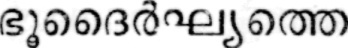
ഭൂദൈര്‍ഘ്യത്തെ
